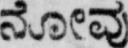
ನೋವು
